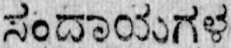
ಸಂದಾಯಗಳ
